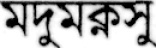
মদুমক্নসু
